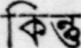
কিন্তু
